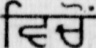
ਵਿਚੋਂ
